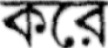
করে
